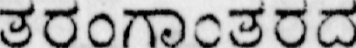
ತರಂಗಾಂತರದ
